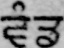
ਵੰਡ
